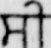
ਸੀ
